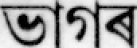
ভাগৰ
